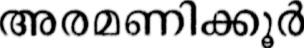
അരമണിക്കൂര്‍
